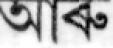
আৰু
